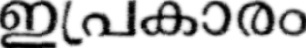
ഇപ്രകാരം
